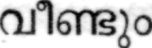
വീണ്ടും
